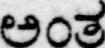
ಅಂತ
